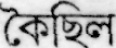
কৈছিল
